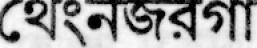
থেংনজরগা
